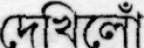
দেখিলোঁ
